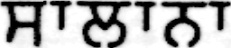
ਸਾਲਾਨਾ
